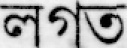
লগত
